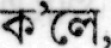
ক'লে,
